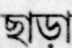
ছাড়া
